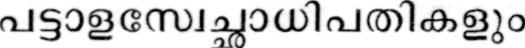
പട്ടാളസ്വേച്ഛാധിപതികളും
